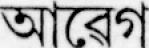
আৱেগ
